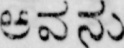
ಅವನು
